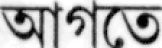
আগতে
